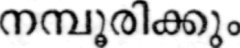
നമ്പൂരിക്കും
